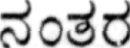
ನಂತರ
